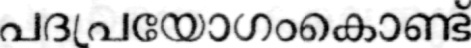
പദപ്രയോഗംകൊണ്ട്
